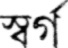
স্বর্গ
